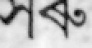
সৰু
